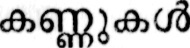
കണ്ണുകള്‍
